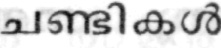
ചണ്ടികള്‍
